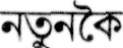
নতুনকৈ
